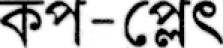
কপ-প্লেৎ
